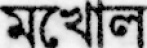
মখোল
